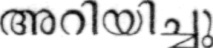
അറിയിച്ചു
